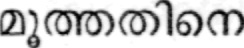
മൂത്തതിനെ
